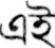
এই
